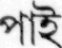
পাই
